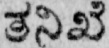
ತನಿಖೆ
